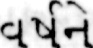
વર્ષને
